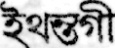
ইথন্তগী
